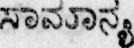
ಸಾಮಾನ್ಯ
